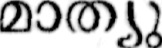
മാത്യു
